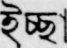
ইচ্ছা
